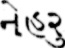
નેહરુ
